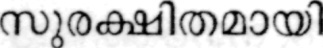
സുരക്ഷിതമായി
